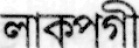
লাকপগী
